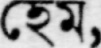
হেম,
